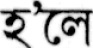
হ'লে
